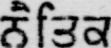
ਨੈਤਿਕ
